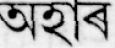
অহাৰ
